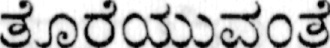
ತೊರೆಯುವಂತೆ
